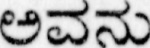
ಅವನು
